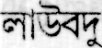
লাউবদু
